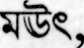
মঊৎ,
